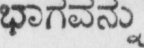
ಭಾಗವನ್ನು
